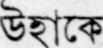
উহাকে
